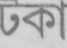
টকা
